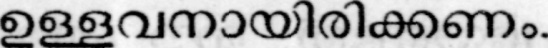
ഉള്ളവനായിരിക്കണം.
